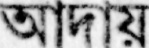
আদায়
